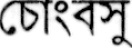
চোংবসু
